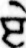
ਏ
